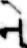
ને
